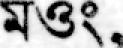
মওং,
